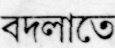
বদলাতে
